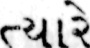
ત્યારે
